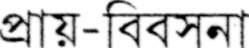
প্রায়-বিবসনা
